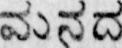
ಮನದ
